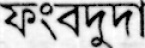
ফংবদুদা
